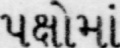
પક્ષોમાં
